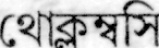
থোক্লম্বসি
